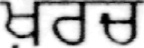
ਖ਼ਰਚ
